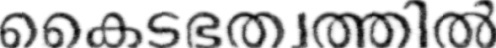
കൈടഭത്വത്തില്‍
